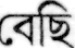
বেছি
